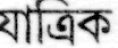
যাত্রিক
